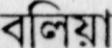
বলিয়া
